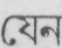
যেন
